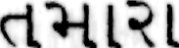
તમારા
